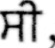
ਸੀ,
